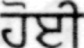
ਹੋਈ
